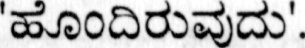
‘ಹೊಂದಿರುವುದು’.
